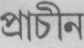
প্রাচীন
